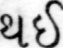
થઈ
